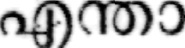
എന്താ
